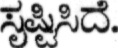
ಸೃಷ್ಟಿಸಿದೆ.
